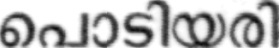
പൊടിയരി
